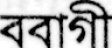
ববাগী
